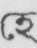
হে
